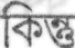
কিন্তু
